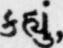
કહ્યું,
